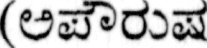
(ಅಪೌರುಷ
